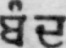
ਬੰਦ
